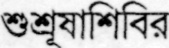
শুশ্রূষাশিবির
